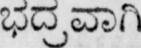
ಭದ್ರವಾಗಿ
